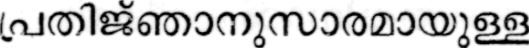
പ്രതിജ്ഞാനുസാരമായുള്ള
